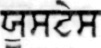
ਯੂਸਟੇਸ
